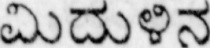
ಮಿದುಳಿನ
